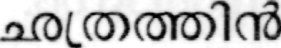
ഛത്രത്തിന്‍
